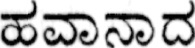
ಹವಾನಾದ
